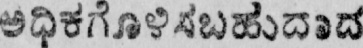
ಅಧಿಕಗೊಳಿಸಬಹುದಾದ
